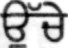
ਉੱਚੇ
